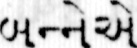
બન્નેએ
